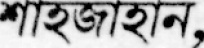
শাহজাহান,
